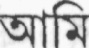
আমি
